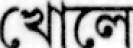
খোলে
